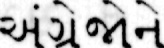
અંગ્રેજોને
